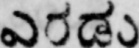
ಎರಡು
